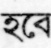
হবে
